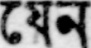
যেন
